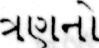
ત્રણનો
